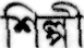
শিল্পী
